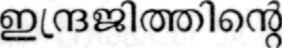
ഇന്ദ്രജിത്തിന്റെ
